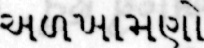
અળખામણો
